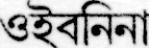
ওইবনিনা
